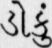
ડોકું
